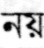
নয়
